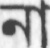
না
